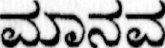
ಮಾನವ
